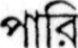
পারি
